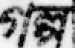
গল্প
